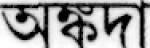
অঙ্কদা
